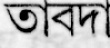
তাবদা
